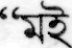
"মই
